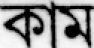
কাম
